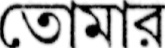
তোমার
